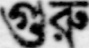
গুরু
